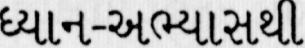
ધ્યાન-અભ્યાસથી
